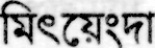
মিৎয়েংদা
